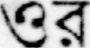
ওর
